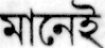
মানেই
